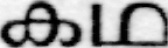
കഥ
